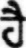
ਹੈ
